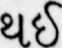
થઈ
